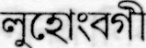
লুহোংবগী
